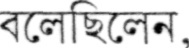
বলেছিলেন,
